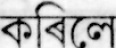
কৰিলে
